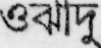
ওঝাদু
